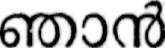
ഞാന്‍
